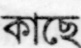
কাছে
